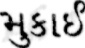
મુકાઈ
